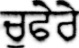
ਚੁਫੇਰੇ
